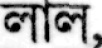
লাল,
